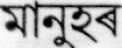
মানুহৰ
